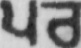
ਪਰ
